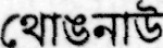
থোঙনাউ
